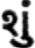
શું
